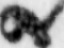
જ
